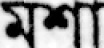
মশা
